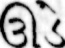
ઊંડે
